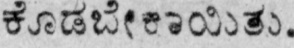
ಕೊಡಬೇಕಾಯಿತು.
